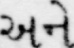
અને
